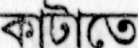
কাটাতে
